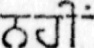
ਨਹੀਂ
